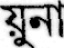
য়ুনা
